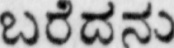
ಬರೆದನು
